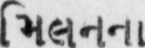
મિલનના
